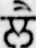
ਲੈ
